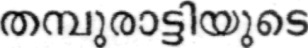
തമ്പുരാട്ടിയുടെ
